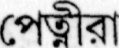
পেত্নীরা
